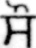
ਸੌ
